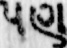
પણ
